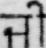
ਜੀ
